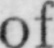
of
